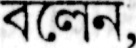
বলেন,
